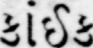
કાંઈક
